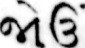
જોઉં
